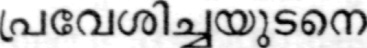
പ്രവേശിച്ചയുടനെ
